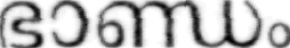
ഭാണ്ഡം
